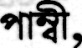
পাম্বী,
